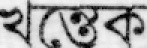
খন্তেক
